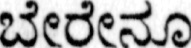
ಬೇರೇನೂ
